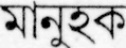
মানুহক
